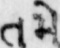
તમે
